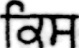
ਕਿਸ
